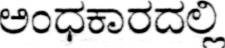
ಅಂಧಕಾರದಲ್ಲಿ
